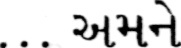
...અમને
